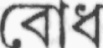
বোধ
